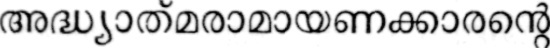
അദ്ധ്യാത്മരാമായണക്കാരന്റെ
